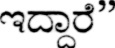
ಇದ್ದಾರೆ"
